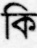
কি
